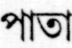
পাতা
